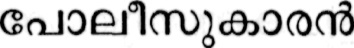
പോലീസുകാരന്‍
